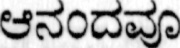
ಆನಂದವೂ
